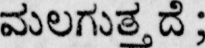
ಮಲಗುತ್ತದೆ;
